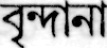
বৃন্দানা
